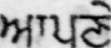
ਆਪਣੇ
